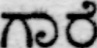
ಗಾರೆ
